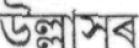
উল্লাসৰ
